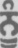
ਨੂੰ
